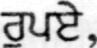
ਰੁਪਏ,
